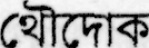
থৌদোক
